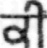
ਕੀ
